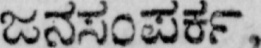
ಜನಸಂಪರ್ಕ
